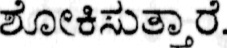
ಶೋಕಿಸುತ್ತಾರೆ.
